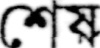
শেষ
